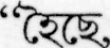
"হৈছে,
